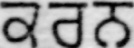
ਕਰਨ
